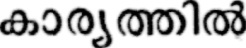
കാര്യത്തില്‍
